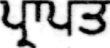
ਪ੍ਰਾਪਤ
